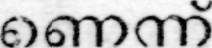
ണെന്ന്
